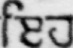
ਇਹ
